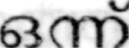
ഒന്ന്
